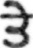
ਤੇ
